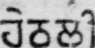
ਹੇਠਲੀ
